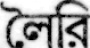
লৈরি
